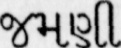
જમણી
